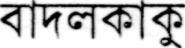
বাদলকাকু
